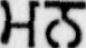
ਮਨ
